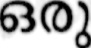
ഒരു
